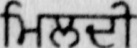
ਮਿਲਦੀ
